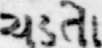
ચડતો
